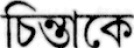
চিন্তাকে
